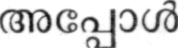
അപ്പോള്‍
